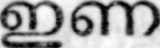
ഇണ
